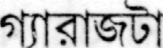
গ্যারাজটা
